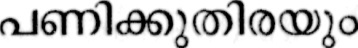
പണിക്കുതിരയും
